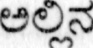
ಅಲ್ಲಿನ
